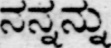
ನನ್ನನ್ನು
